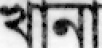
খানা
